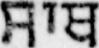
ਸਾਥ
